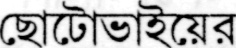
ছোটোভাইয়ের
